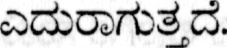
ಎದುರಾಗುತ್ತದೆ.
